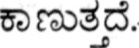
ಕಾಣುತ್ತದೆ.
